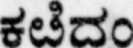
ಕೞದಂ
